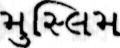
મુસ્લિમ
